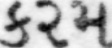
કરમ
